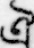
ঐ
